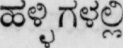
ಹಳ್ಳಿಗಳಲ್ಲಿ
